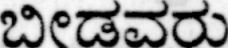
ಬೀಡವರು
